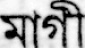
মাগী
